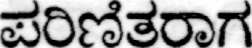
ಪರಿಣಿತರಾಗ
